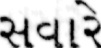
સવારે
